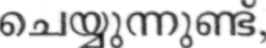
ചെയ്യുന്നുണ്ട്,
